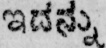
ಇದನ್ನು
